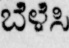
ಬೆಳೆಸಿ
